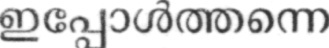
ഇപ്പോള്‍ത്തന്നെ
